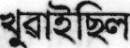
খুৱাইছিল
